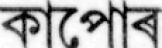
কাপোৰ
